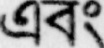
এবং
